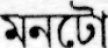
মনটো
